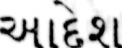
આદેશ
